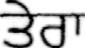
ਤੇਰਾ
